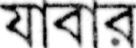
যাবার
